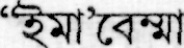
“ইমা’বেম্মা
